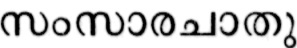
സംസാരചാതു
